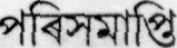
পৰিসমাপ্তি
